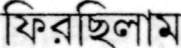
ফিরছিলাম
